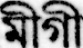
মীগী
